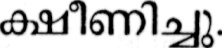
ക്ഷീണിച്ചു.
